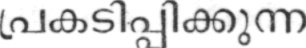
പ്രകടിപ്പിക്കുന്ന
